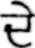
ਦੇ
